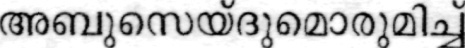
അബുസെയ്ദുമൊരുമിച്ച്
